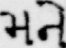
મને
